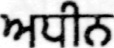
ਅਧੀਨ
